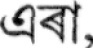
এৰা,
